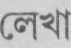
লেখা
